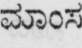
ಮಾಂಸ
